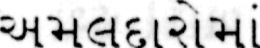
અમલદારોમાં
